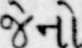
જેનો
